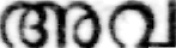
അവ
